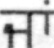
ਜਾਂ
